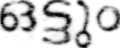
ഒട്ടും
